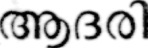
ആദരി
